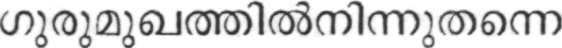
ഗുരുമുഖത്തില്‍നിന്നുതന്നെ
